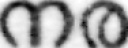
നര
